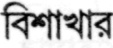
বিশাখার
